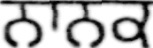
ਨਾਨਕ
